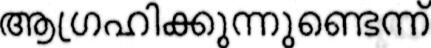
ആഗ്രഹിക്കുന്നുണ്ടെന്ന്
